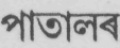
পাতালৰ
